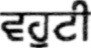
ਵਹੁਟੀ
